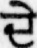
ਦੇ
